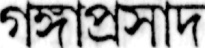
গঙ্গাপ্রসাদ
